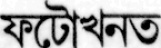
ফটোখনত
